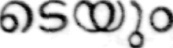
ടെയും
